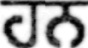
ਹਨ
